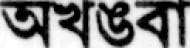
অখঙবা
